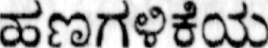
ಹಣಗಳಿಕೆಯ
